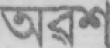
অৱশ
